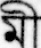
মী
